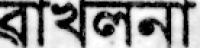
ৱাখলনা
